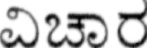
ವಿಚಾರ
